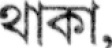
থাকা,
